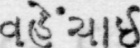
વહેંચાઈ
